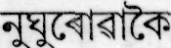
নুঘুৰোৱাকৈ
